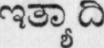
ಇತ್ಯಾದಿ
